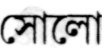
সোলো
